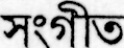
সংগীত
